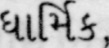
ધાર્મિક,
